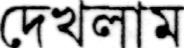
দেখলাম
